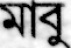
মাবু
